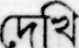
দেখি
